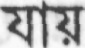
যায়
